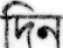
দিন
